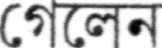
গেলেন
